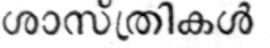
ശാസ്ത്രികള്‍
